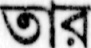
তার
